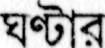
ঘণ্টার
